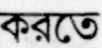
করতে
